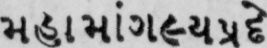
મહામાંગલ્યપ્રદે
